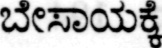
ಬೇಸಾಯಕ್ಕೆ
